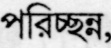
পরিচ্ছন্ন,
